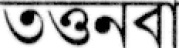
তত্তনবা
